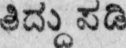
ತಿದ್ದುಪಡಿ
